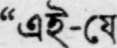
‘‘এই-যে
